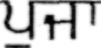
ਪੁਜਾ
